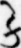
કે
